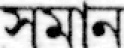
সমান
